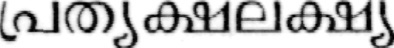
പ്രത്യക്ഷലക്ഷ്യ
